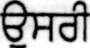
ਉਸਰੀ
